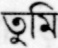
তুমি
